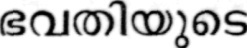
ഭവതിയുടെ
